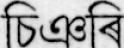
চিঞৰি
